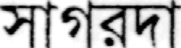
সাগরদা
